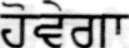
ਹੋਵੇਗਾ
